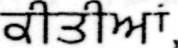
ਕੀਤੀਆਂ,
